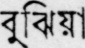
বুঝিয়া
